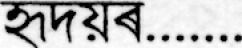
হৃদয়ৰ.......
